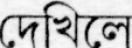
দেখিলে
